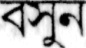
বসুন
